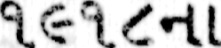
૧૯૧૮ના
